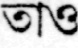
তাও
